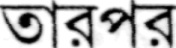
তারপর
